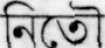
নিতৌ
